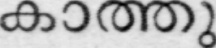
കാത്തു
